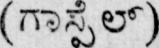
(ಗಾಸ್ಪೆಲ್)
